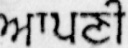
ਆਪਣੀ
